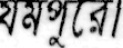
যমপুরে।
